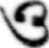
ও
